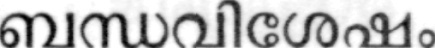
ബന്ധവിശേഷം
